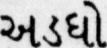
અડધો
